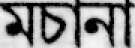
মচানা
